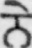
ਨੇ
